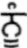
ਨੂੰ
